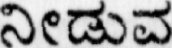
ನೀಡುವ
